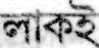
লাকই
